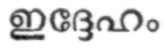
ഇദ്ദേഹം
